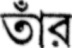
তাঁর
